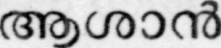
ആശാന്‍
